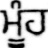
ਮੂੰਹ
